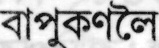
বাপুকণলৈ
